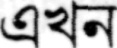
এখন
